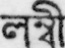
লম্বী
